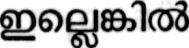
ഇല്ലെങ്കില്‍
